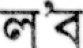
ল'ব
